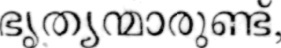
ഭൃത്യന്മാരുണ്ട്,
